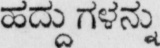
ಹದ್ದುಗಳನ್ನು
